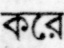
করে
